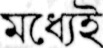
মধ্যেই
